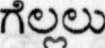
ಗೆಲ್ಲಲು
